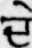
ਦੇ
